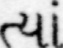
ત્યાં
